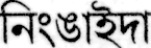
নিংঙাইদা
